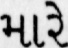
મારે
